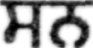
ਸਨ
